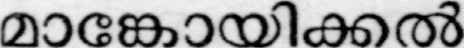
മാങ്കോയിക്കല്‍
